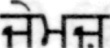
ਜੇਮਜ਼
